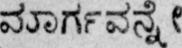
ಮಾರ್ಗವನ್ನೇ
